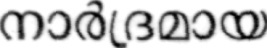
നാര്‍ദ്രമായ
